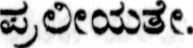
ಪ್ರಲೀಯತೇ.
